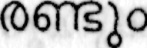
രണ്ടും
